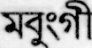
মবুংগী
